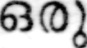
ഒരു
